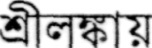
শ্রীলঙ্কায়
